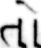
તો
